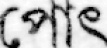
পোৎ
